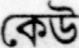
কেউ
